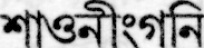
শাওনীংগনি
